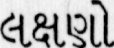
લક્ષણો
